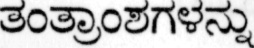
ತಂತ್ರಾಂಶಗಳನ್ನು
